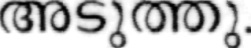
അടുത്തു.
